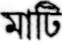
মাটি
